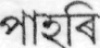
পাহৰি
